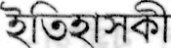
ইতিহাসকী
